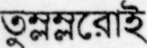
তুম্লম্লরোই
